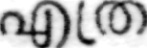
എത്ര
